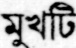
মুখটি
